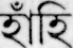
হাঁহি
